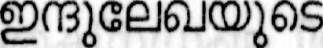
ഇന്ദുലേഖയുടെ
